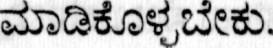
ಮಾಡಿಕೊಳ್ಳಬೇಕು.
